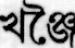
খঞ্জৈ
